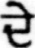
ਦੇ
